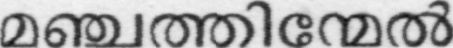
മഞ്ചത്തിന്മേല്‍
